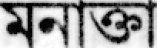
মনাক্তা
